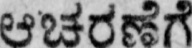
ಆಚರಣೆಗೆ
